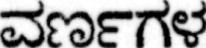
ವರ್ಣಗಳ
